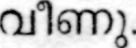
വീണു.
